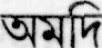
অমদি
